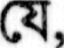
যে,
